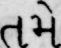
તમે
